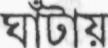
ঘাঁটায়
